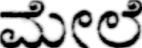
ಮೇಲೆ
